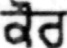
ਕੌਰ
